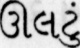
ઊલટું
